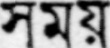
সময়
